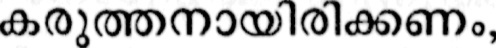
കരുത്തനായിരിക്കണം,
